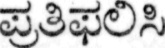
ಪ್ರತಿಫಲಿಸಿ
